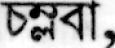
চম্লবা,
